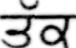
ਤੱਕ
